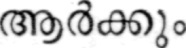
ആര്‍ക്കും
